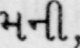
મની,
